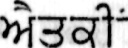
ਐਤਕੀਂ
